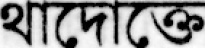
থাদোক্তে
